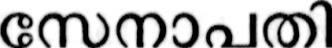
സേനാപതി
